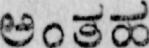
ಅಂತಹ
